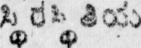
ಸ್ಥಿರಸ್ಥಿತಿಯ
